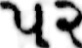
પર
